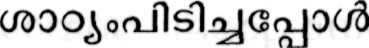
ശാഠ്യംപിടിച്ചപ്പോള്‍
